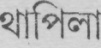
থাপিলা
